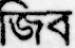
জিবা
